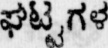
ಘಟ್ಟಗಳ
